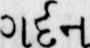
ગર્દન
